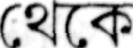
থেকে
